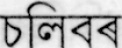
চলিবৰ
